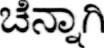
ಚೆನ್ನಾಗಿ
